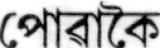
পোৱাকৈ
